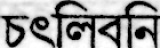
চৎলিবনি
